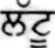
ਲੱਟੂ
